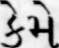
કેમે
